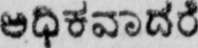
ಅಧಿಕವಾದರೆ
